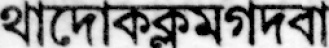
থাদোকক্লমগদবা
